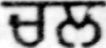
ਚਲ
